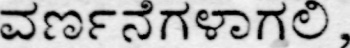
ವರ್ಣನೆಗಳಾಗಲಿ,
